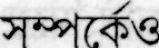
সম্পর্কেও
